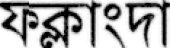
ফক্লাংদা
